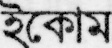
ইকোম
